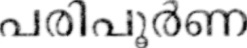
പരിപൂര്‍ണ
